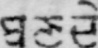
ਬਣਦੇ
